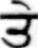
ਤੇ
